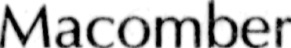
Macomber
